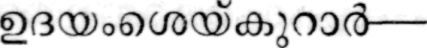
ഉദയംശെയ്കുറാര്‍-
